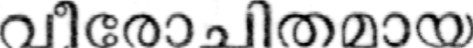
വീരോചിതമായ
